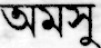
অমসু
